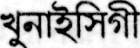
খুনাইসিগী
